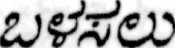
ಬಳಸಲು
